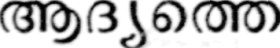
ആദ്യത്തെ
